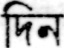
দিন
